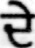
ਦੇ
